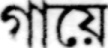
গায়ে
